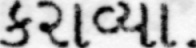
કરાવ્યા.
